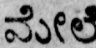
ಮೇಲೆ
